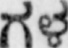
ಗಳ
